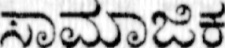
ಸಾಮಾಜಿಕ
